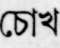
চোখ
